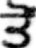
ਤੋਂ
